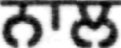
ਨਾਲ
